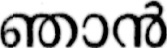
ഞാന്‍
